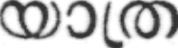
യാത്ര
